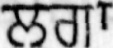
ਲਗਾ
